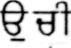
ਉਚੀ
